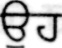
ਉਹ
